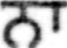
ਨਾ
